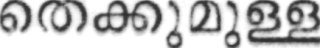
തെക്കുമുള്ള
